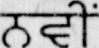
ਨਵੀਂ
